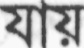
যায়
